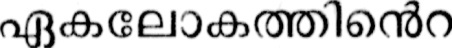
ഏകലോകത്തിന്റെ
